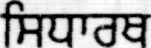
ਸਿਧਾਰਥ
